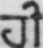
ਹੀ
